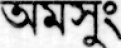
অমসুং
